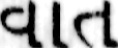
વાત
